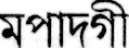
মপাদগী
